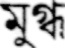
মুগ্ধ
